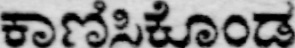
ಕಾಣಿಸಿಕೊಂಡ
